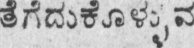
ತೆಗೆದುಕೊಳ್ಳುವ
